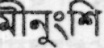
মীনুংশি
